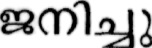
ജനിച്ചു
